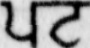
ਪਟ
